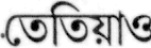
তেতিয়াও
